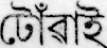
টোঁৱাই
